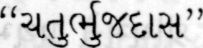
"ચતુર્ભુજદાસ"
